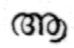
ആ
